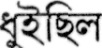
ধুইছিল
